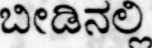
ಬೀಡಿನಲ್ಲಿ
